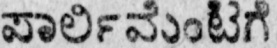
ಪಾರ್ಲಿಮೆಂಟಿಗೆ
